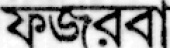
ফজরবা
